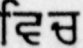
ਵਿਚ
